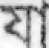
যা
